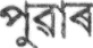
পুৱাৰ
